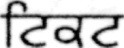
ਟਿਕਟ
